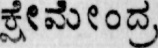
ಕ್ಷೇಮೇಂದ್ರ
